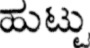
ಹುಟ್ಟು
